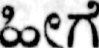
ಹೀಗೆ
